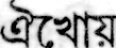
ঐখোয়
